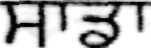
ਸਾਡਾ
